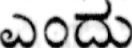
ಎಂದು
